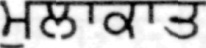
ਮੁਲਾਕਾਤ
